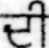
ਦੀ
